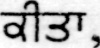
ਕੀਤਾ,
